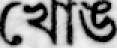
খোঙ
